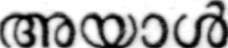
അയാള്‍
